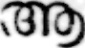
ആ
